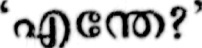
‘എന്തേ?’
